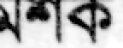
মশক
